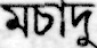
মচাদু
